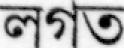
লগত
